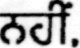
ਨਹੀਂ,
